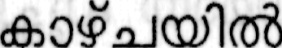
കാഴ്ചയില്‍
